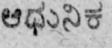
ಆಧುನಿಕ
